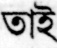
তাই
